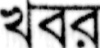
খবর
